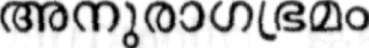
അനുരാഗഭ്രമം
